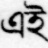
এই
